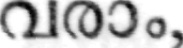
വരാം,
